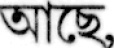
আছে,
